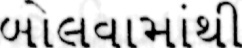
બોલવામાંથી
